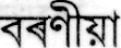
বৰণীয়া
